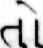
તો
